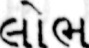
લોભ
